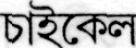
চাইকেল
